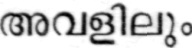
അവളിലും
